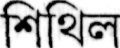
শিথিল
